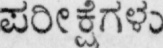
ಪರೀಕ್ಷೆಗಳು
